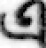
এ
